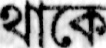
থাকে
